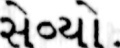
સેવ્યો.
